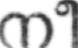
നീ
